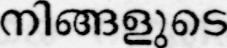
നിങ്ങളുടെ
